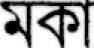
মকা
